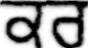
ਕਰ
